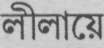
লীলায়ে
